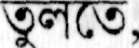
তুলতে,
